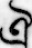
ঐ
